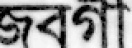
জবগী
